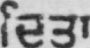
ਦਿਤਾ
